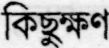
কিছুক্ষণ
